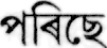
পৰিছে
